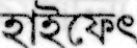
হাইফেৎ
